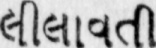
લીલાવતી
